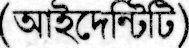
(আইদেন্টিটি)
